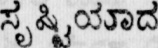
ಸೃಷ್ಟಿಯಾದ
